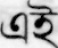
এই
